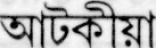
আটকীয়া
